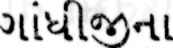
ગાંધીજીના
